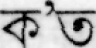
ক'ত
